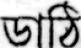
ডাঠি
